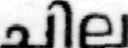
ചില
